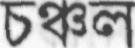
চঞ্চল
